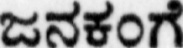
ಜನಕಂಗೆ
